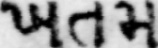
ખતમ
